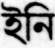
ইনি
